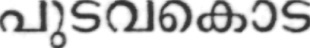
പുടവകൊട
